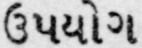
ઉપયોગ
